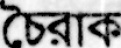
চৈরাক
